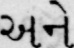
અને
